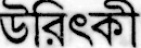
উরিৎকী
